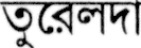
তুরেলদা
